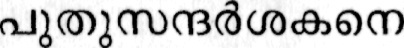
പുതുസന്ദര്‍ശകനെ
